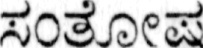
ಸಂತೋಷ
